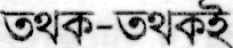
তথক-তথকই
